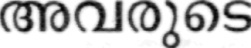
അവരുടെ
